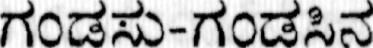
ಗಂಡಸು-ಗಂಡಸಿನ
